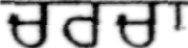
ਚਰਚਾ
